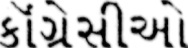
કૉંગ્રેસીઓ
